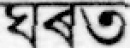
ঘৰত
